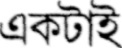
একটাই
